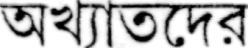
অখ্যাতদের
